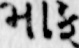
માફ
